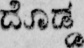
ದೊಡ್ಡ
